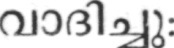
വാദിച്ചു:
